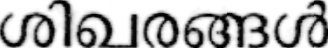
ശിഖരങ്ങള്‍
